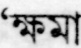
‘ক্ষমা
